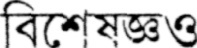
বিশেষজ্ঞও
